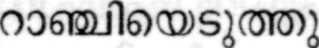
റാഞ്ചിയെടുത്തു
